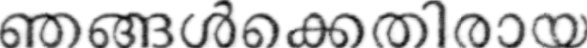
ഞങ്ങള്‍ക്കെതിരായ
